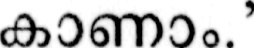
കാണാം.’
